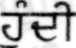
ਹੁੰਦੀ
